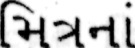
મિત્રનાં
